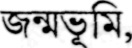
জন্মভূমি,
